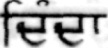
ਦਿੰਦਾ
